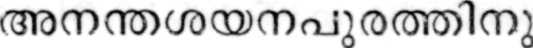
അനന്തശയനപുരത്തിനു
